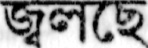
জ্বলছে
